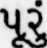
પૂરું
